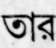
তার
